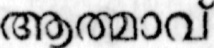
ആത്മാവ്
